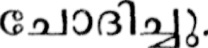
ചോദിച്ചു.
